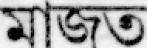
মাজত
